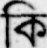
কি
